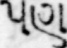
પણ
